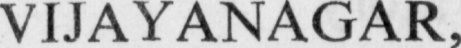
VIJAYANAGAR,
